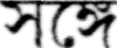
সঙ্গে
